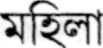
মহিলা
